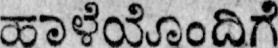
ಹಾಳೆಯೊಂದಿಗೆ
